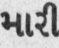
મારી
